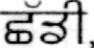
ਛੱਡੀ,
